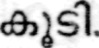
കൂടി.
